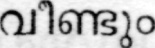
വീണ്ടും
